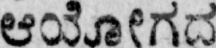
ಆಯೋಗದ
